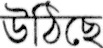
উঠিছে
